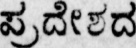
ಪ್ರದೇಶದ
